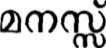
മനസ്സ്
